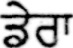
ਡੇਰਾ
